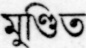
মুণ্ডিত
